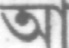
আ
